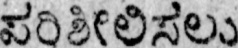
ಪರಿಶೀಲಿಸಲು
